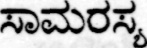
ಸಾಮರಸ್ಯ
